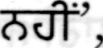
ਨਹੀਂ',
